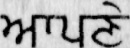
ਆਪਣੇ
